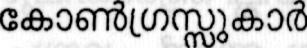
കോണ്‍ഗ്രസ്സുകാര്‍
